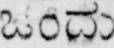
ಒಂದು
